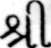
શ્રી
